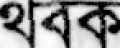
থবক
